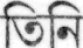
তিনি
